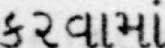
કરવામાં
